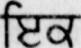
ਇਕ
